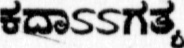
ಕದಾssಗತ್ಯ
